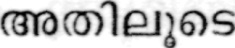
അതിലൂടെ
